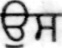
ਉਸ
